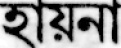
হায়না
